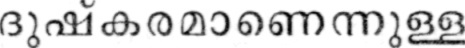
ദുഷ്കരമാണെന്നുള്ള
